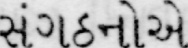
સંગઠનોએ
